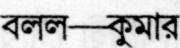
বলল–কুমার
